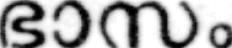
ഭാസം
